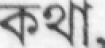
কথা,
